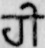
ਹੀ
